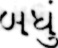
બધું
